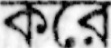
করে
